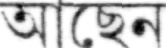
আছেন
